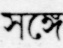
সঙ্গে
